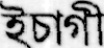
ইচাগী
